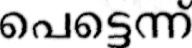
പെട്ടെന്ന്
